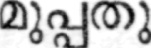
മുപ്പതു
